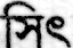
সিৎ
